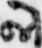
જો
